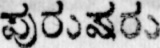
ಪುರುಷರು
